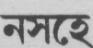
নসহে
